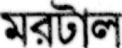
মরটাল
